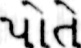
પોતે
